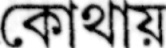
কোথায়
